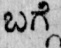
ಬಗ್ಗೆ
